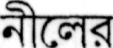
নীলের
